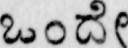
ಒಂದೇ
